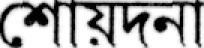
শোয়দনা
